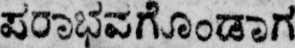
ಪರಾಭವಗೊಂಡಾಗ
